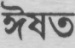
ঈষত
